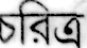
চরিত্র
